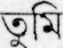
তুমি
